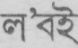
ল'বই
